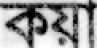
কয়া
